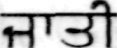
ਜਾਤੀ
